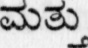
ಮತ್ತು
